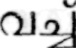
വച്ച്‌
